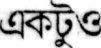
একটুও
